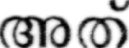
അത്
